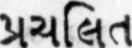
પ્રચલિત
